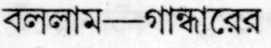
বললাম–গান্ধারের
